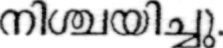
നിശ്ചയിച്ചു.
